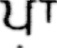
ਪਾ
